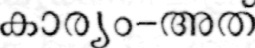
കാര്യം-അത്
